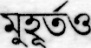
মুহূর্তও
